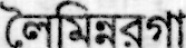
লৈমিন্নরগা
